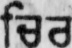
ਚਿਰ
